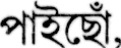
পাইছোঁ,
